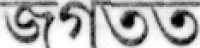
জগতত
